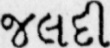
જલદી
